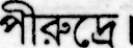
পীরুদ্রে।
